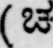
(ಚ
